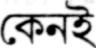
কেনই
